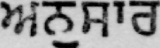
ਅਨੁਸਾਰ
